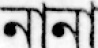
নানা
